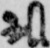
શ્રી
